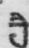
ਹੈ
